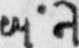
બંને
